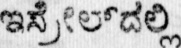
ಇಸ್ರೇಲ್‌ದಲ್ಲಿ
